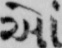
ઓં
